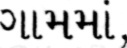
ગામમાં,
